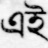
এই
